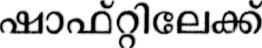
ഷാഫ്റ്റിലേക്ക്
